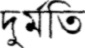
দুর্মতি
